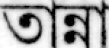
তান্না
